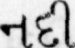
નદી
